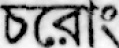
চরোং
